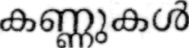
കണ്ണുകള്‍
